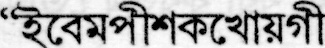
“ইবেমপীশকখোয়গী
